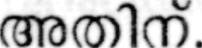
അതിന്.
